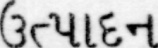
ઉત્પાદન
